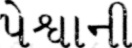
પેશ્વાની
